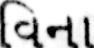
વિના
